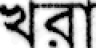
খরা
